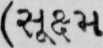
(સૂક્ષ્મ
